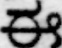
ಈ
